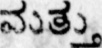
ಮತ್ತು
